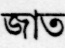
জাত
